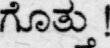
ಗೊತ್ತು!
